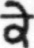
ਕੇ
